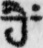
ਹੈਂ
